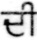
ਦੀ
